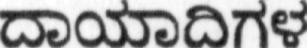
ದಾಯಾದಿಗಳ
